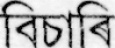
বিচাৰি
